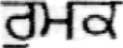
ਰੁਮਕ
